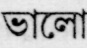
ভালো
